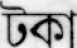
টকা
